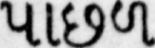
પાછળ
